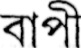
বাপী
